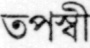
তপস্বী
